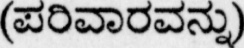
(ಪರಿವಾರವನ್ನು)
